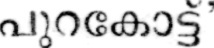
പുറകോട്ട്'
